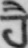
ਹੈ
